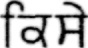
ਕਿਸੇ
